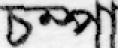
চম্পা
